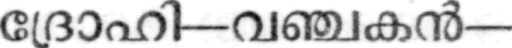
ദ്രോഹി-വഞ്ചകന്‍-
